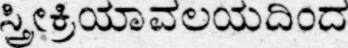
ಸ್ತ್ರೀಕ್ರಿಯಾವಲಯದಿಂದ
